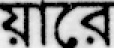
য়ারে
